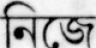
নিজে
